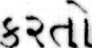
કરતો
